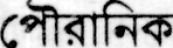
পৌরানিক
